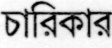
চারিকার
